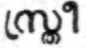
സ്ത്രീ
